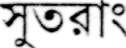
সুতরাং
